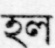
হল
